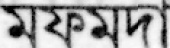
মফমদা
